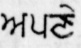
ਅਪਣੇ
